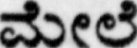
ಮೇಲೆ
